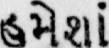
હમેશાં
